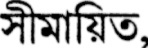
সীমায়িত,
